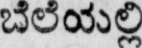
ಬೆಲೆಯಲ್ಲಿ
